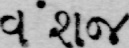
વંશજ
